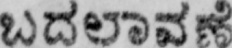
ಬದಲಾವಣೆ
